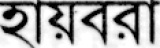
হায়বরা
